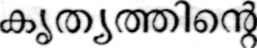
കൃത്യത്തിന്റെ
